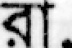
রা.
